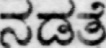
ನಡತೆ
